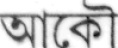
আকৌ
